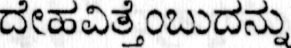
ದೇಹವಿತ್ತೆಂಬುದನ್ನು
